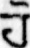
ਹੋ
